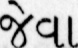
જેવા
